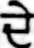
ਦੇ
